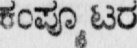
ಕಂಪ್ಯೂಟರ
